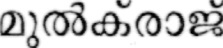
മുല്‍ക്‌രാജ്
